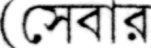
(সেবার
